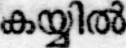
കയ്യില്‍
